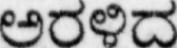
ಅರಳಿದ
